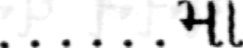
...મા
